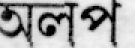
অলপ
